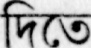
দিতে
